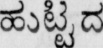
ಹುಟ್ಟಿದ
